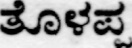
ತೊಳಪ್ಪ
